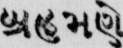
ઈશાય
